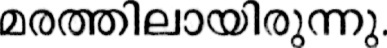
മരത്തിലായിരുന്നു.
